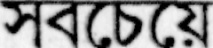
সবচেয়ে
